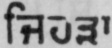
ਜਿਹੜਾ
